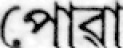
পোৱা
